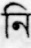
নি
